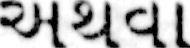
અથવા
